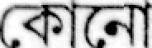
কোনো
